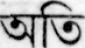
অতি
